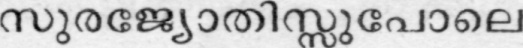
സുരജോതിസ്സുപോലെ
